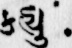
કહ્યું.
